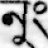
নুং
